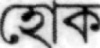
হোক
